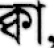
ক্বা,
